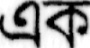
এক
